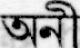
অনী
